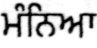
ਮੰਨਿਆ
